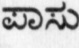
ಪಾಸು
